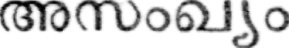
അസംഖ്യം
